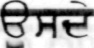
ਉਸਦੇ
